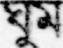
ঘুম
